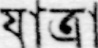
যাত্রা
